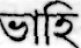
ভাহি
